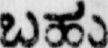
ಬಹು
